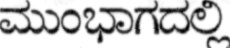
ಮುಂಭಾಗದಲ್ಲಿ
